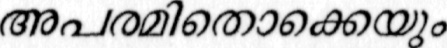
അപരമിതൊക്കെയും
